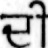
ਦੀ
